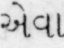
એવા
